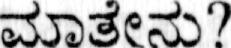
ಮಾತೇನು?
